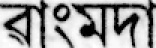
ৱাংমদা
